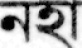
নহা
